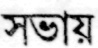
সভায়
